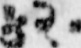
કર-
